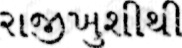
રાજીખુશીથી
